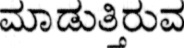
ಮಾಡುತ್ತಿರುವ
